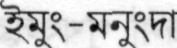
ইমুং-মনুংদা
